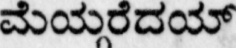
ಮೆಯ್ಗರೆದಯ್
